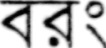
বরং
